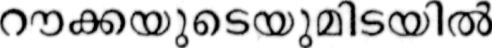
റൌക്കയുടെയുമിടയില്‍
